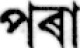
পৰা
